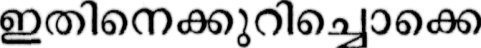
ഇതിനെക്കുറിച്ചൊക്കെ
